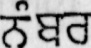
ਨੰਬਰ
